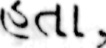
હતા,
